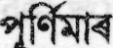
পূৰ্ণিমাৰ
